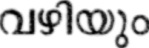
വഴിയും
